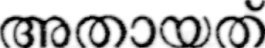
അതായത്
